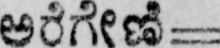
ಅರೆಗೇಣಿ=
